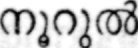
നൂറുല്‍
